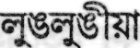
লুঙলুঙীয়া
